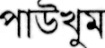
পাউখুম
